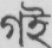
গই
